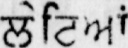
ਲੇਟਿਆਂ
